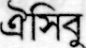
ঐসিবু
